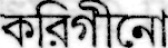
করিগীনো
